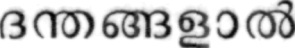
ദന്തങ്ങളാല്‍
